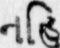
નહિ
